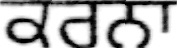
ਕਰਨਾ
